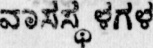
ವಾಸಸ್ಥಳಗಳ
